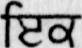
ਇਕ
